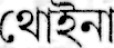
থোইনা
